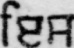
ਇਸ
